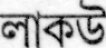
লাকউ
